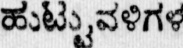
ಹುಟ್ಟುವಳಿಗಳ
